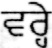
ਵਰ੍ਹੇ
